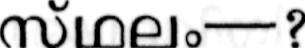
സ്ഥലം-?
